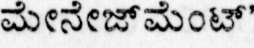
ಮೇನೇಜ್‌ಮೆಂಟ್’
